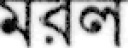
মরল
